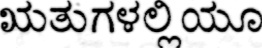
ಋತುಗಳಲ್ಲಿಯೂ
